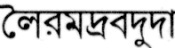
লৈরমদ্রবদুদা
